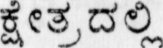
ಕ್ಷೇತ್ರದಲ್ಲಿ
